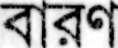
বারণ
